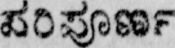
ಪರಿಪೂರ್ಣ
